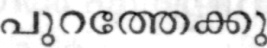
പുറത്തേക്കു
